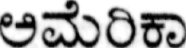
ಅಮೆರಿಕಾ
